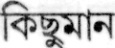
কিছুমান
